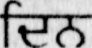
ਦਿਨ
